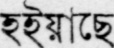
হইয়াছে
